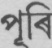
পূৰি
